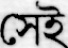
সেই
